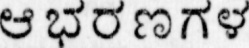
ಆಭರಣಗಳ
